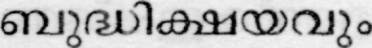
ബുദ്ധിക്ഷയവും
